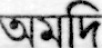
অমদি
